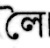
লৈ।
